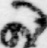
જે
